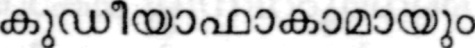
കുഡീയാഫാകാമായും
